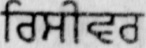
ਰਿਸੀਵਰ
